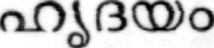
ഹൃദയം
